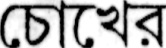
চোখের
